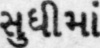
સુધીમાં
